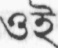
ওই
